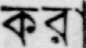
করা
